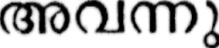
അവന്നു
